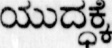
ಯುದ್ಧಕ್ಕೆ
